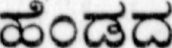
ಹೆಂಡದ
